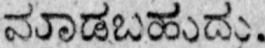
ಮಾಡಬಹುದು.
